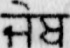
ਜੇਬ
